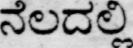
ನೆಲದಲ್ಲಿ
